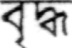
বৃদ্ধ
